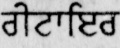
ਰੀਟਾਇਰ
